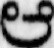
ಆ
